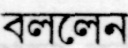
বললেন
